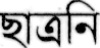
ছাত্রনি
